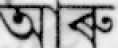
আৰু
